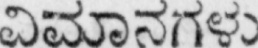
ವಿಮಾನಗಳು
